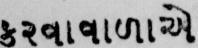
કરવાવાળાએ
